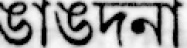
ঙাঙদনা
